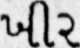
ખીર
